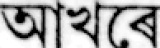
আখৰে
